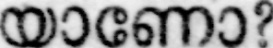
യാണോ?
